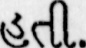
હતી.
